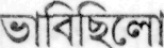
ভাবিছিলো
